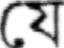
যে
